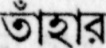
তাঁহার
